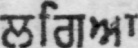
ਲਗਿਆ
